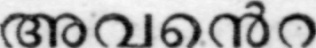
അവന്റെ
